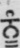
ਨੂੰ
